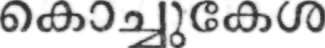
കൊച്ചുകേശ
